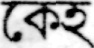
কেহ
